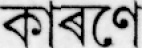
কাৰণে
